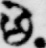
છે.
